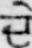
ਦੇ
